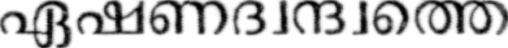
ഏഷണദ്വന്ദ്വത്തെ
